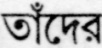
তাঁদের
